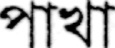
পাখা
